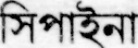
সিপাইনা
